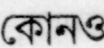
কোনও
